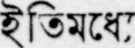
ইতিমধ্যে
